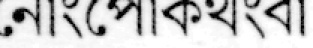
নোংপোকথংবা
